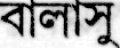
বালাসু
